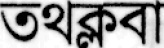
তথক্লবা
